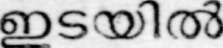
ഇടയില്‍
